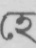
হে
